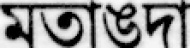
মতাঙদা
